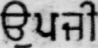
ਉਪਜੀ
